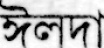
ঈলদা
